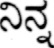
ನಿನ್ನ
